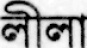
লীলা
